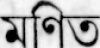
মণিত
